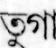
তুগা
